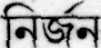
নির্জন
